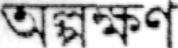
অল্পক্ষণ
